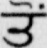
ਤੋਂ
